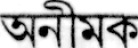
অনীমক
